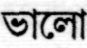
ভালো
